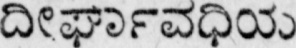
ದೀರ್ಘಾವಧಿಯ
